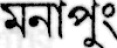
মনাপুং
